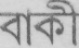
বাকী
